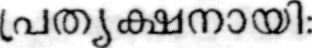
പ്രത്യക്ഷനായി:
